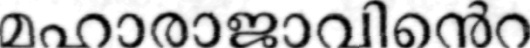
മഹാരാജാവിന്റെ
